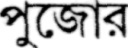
পুজোর
